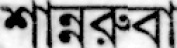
শান্নরুবা
